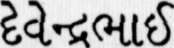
દેવેન્દ્રભાઈ
